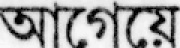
আগেয়ে
